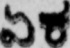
ಏಕ
